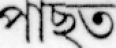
পাছত
